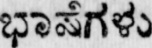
ಭಾಷೆಗಳು
